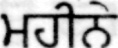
ਮਹੀਨੇ
